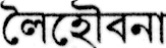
লৈহৌবনা
